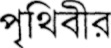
পৃথিবীর
